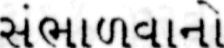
સંભાળવાનો
